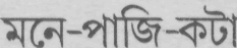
মনে-পাজি-কটা
